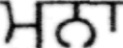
ਮਨਾ
